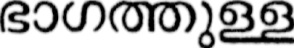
ഭാഗത്തുള്ള
